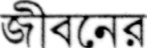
জীবনের
